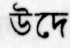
উদে
